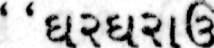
"ઘરઘરાઉ
